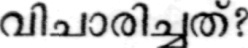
വിചാരിച്ചത്?
